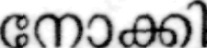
നോക്കി
